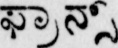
ಫ್ರಾನ್ಸ್
